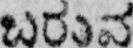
ಬರುವ
